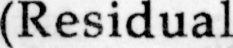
(Residual
